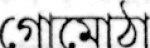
গোমোঠা
